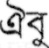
ঐবু
